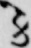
કે
